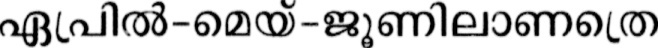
ഏപ്രില്‍-മെയ്-ജൂണിലാണത്രെ
